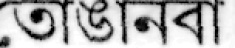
তোঙানবা
